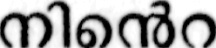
നിന്റെ
